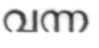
വന്ന
